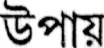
উপায়
